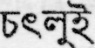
চৎলুই
